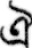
ঐ
